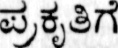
ಪ್ರಕೃತಿಗೆ
